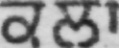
ਕਲਾ
